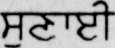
ਸੁਣਾਈ
